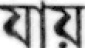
যায়
